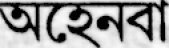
অহেনবা
